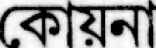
কোয়না
